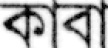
কাবা
